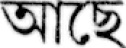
আছে
